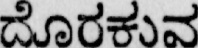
ದೊರಕುವ
